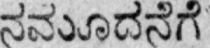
ನಮೂದನೆಗೆ
